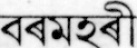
বৰমহৰী
